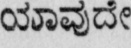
ಯಾವುದೇ
